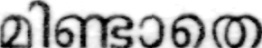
മിണ്ടാതെ
